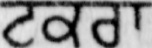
ਟਕਰਾ
